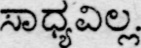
ಸಾಧ್ಯವಿಲ್ಲ.
